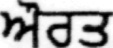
ਔਰਤ
